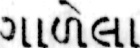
ગાળેલા
